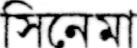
সিনেমা
